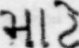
માટે
